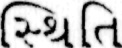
સ્થિતિ
